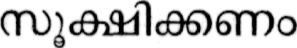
സൂക്ഷിക്കണം
